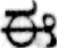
ಈ
